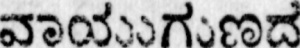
ವಾಯುಗುಣದ
